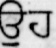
ਉਹ
